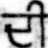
ਦੀ
